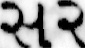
સર
